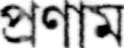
প্রণাম
